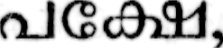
പക്ഷേ,
